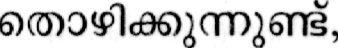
തൊഴിക്കുന്നുണ്ട്,
